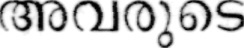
അവരുടെ
